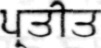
ਪ੍ਰਤੀਤ
